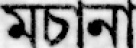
মচানা
